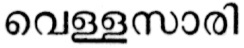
വെള്ളസാരി
